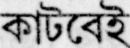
কাটবেই
